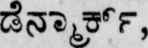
ಡೆನ್ಮಾರ್ಕ್,
